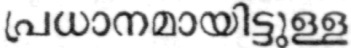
പ്രധാനമായിട്ടുള്ള
